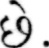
છે.
